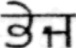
ਭੇਜ
